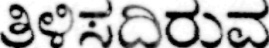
ತಿಳಿಸದಿರುವ
